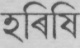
হৰিষি
